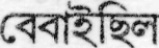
বেবাইছিল
